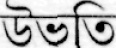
উভতি
